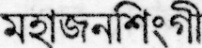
মহাজনশিংগী
